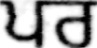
ਪਰ
